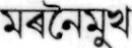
মৰনৈমুখ
